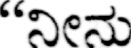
"ನೀನು
